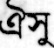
ঐসু
